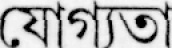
যোগ্যতা
